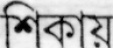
শিকায়
